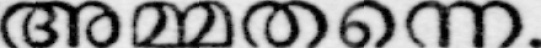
അമ്മതന്നെ.
